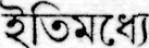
ইতিমধ্যে
